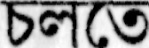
চলতে
